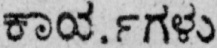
ಕಾರ್ಯಗಳು
